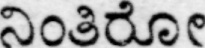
ನಿಂತಿರೋ
